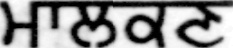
ਮਾਲਕਣ
